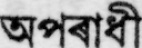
অপৰাধী
